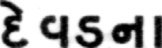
દેવડના
